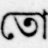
তো
